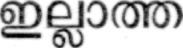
ഇല്ലാത്ത
